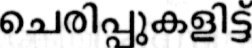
ചെരിപ്പുകളിട്ട്
